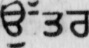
ਉੱਤਰ
